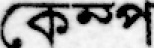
কেম্প
